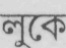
লুকে
